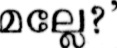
മല്ലേ?’
